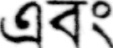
এবং
